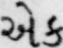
એક
